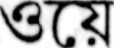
ওয়ে
